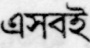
এসবই
